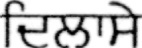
ਦਿਲਾਸੇ
